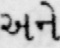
અને
